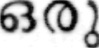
ഒരു
